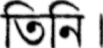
তিনি।
